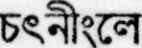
চৎনীংলে
